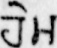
ਹੇਮ
